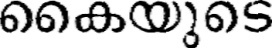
കൈയുടെ
